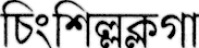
চিংশিল্লক্লগা
